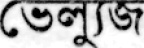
ভেল্যুজ
